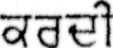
ਕਰਦੀ
